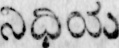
ನಿಧಿಯ
